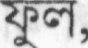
ফুল,
